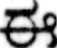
ಈ
